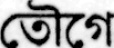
তৌগে
